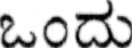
ಒಂದು
